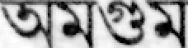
অমগুম
